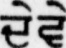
ਦੇਵੇ
